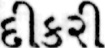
દીકરી
